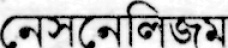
নেসনেলিজম
